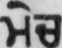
ਮੇਚ
